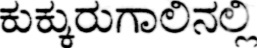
ಕುಕ್ಕುರುಗಾಲಿನಲ್ಲಿ
